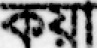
কয়া
